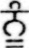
ਨੂੰ
